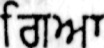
ਗਿਆ
